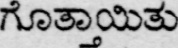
ಗೊತ್ತಾಯಿತು
